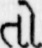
તો
